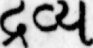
દ્રવ્ય
